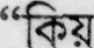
"কিয়
